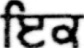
ਇਕ
